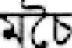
মচৈ
